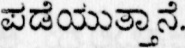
ಪಡೆಯುತ್ತಾನೆ.
